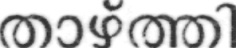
താഴ്ത്തി
